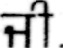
ਜੀ.
